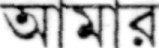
আমার
